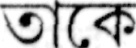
তাকে
